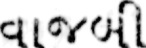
વાજબી
